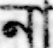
না
